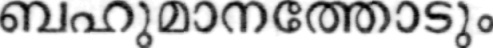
ബഹുമാനത്തോടും
